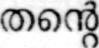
തന്റെ
